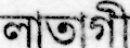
লাতাগী
